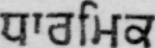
ਧਾਰਮਿਕ
